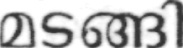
മടങ്ങി
